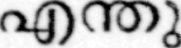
എന്തു
